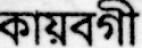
কায়বগী
